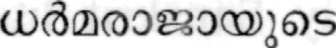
ധര്‍മരാജായുടെ
